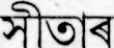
সীতাৰ
